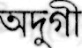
অদুগী
